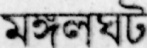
মঙ্গলঘট
